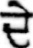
ਦੇ
